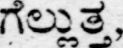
ಗೆಲ್ಲುತ್ತ,
